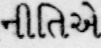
નીતિએ
